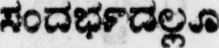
ಸಂದರ್ಭದಲ್ಲೂ
